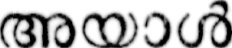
അയാള്‍
